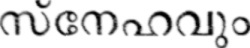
സ്നേഹവും
